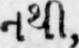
નથી,
